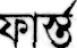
ফার্স্ত
